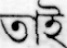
তাই
